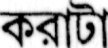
করাটা
